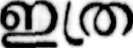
ഇത്ര
